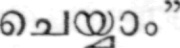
ചെയ്യാം”
